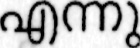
എന്നു
